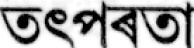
তৎপৰতা
